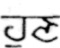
ਹੁਣ
